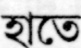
হাতে
